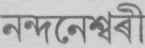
নন্দনেশ্বৰী
